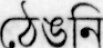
ঠেঙনি
